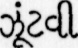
ઝૂંટવી
